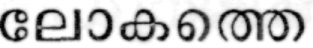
ലോകത്തെ
